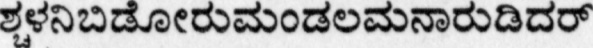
ಶ್ಚಳನಿಬಿಡೋರುಮಂಡಮನಾರುಡಿದರ್
